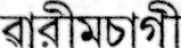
ৱারীমচাগী
